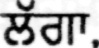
ਲੱਗਾ,
